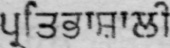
ਪ੍ਰਤਿਭਾਸ਼ਾਲੀ
